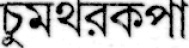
চুমথরকপা
